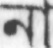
না
